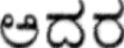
ಅದರ
